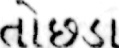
તોછડા
